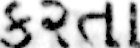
કરતા
